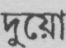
দুয়ো
